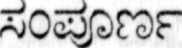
ಸಂಪೂರ್ಣ
